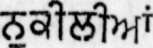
ਨੁਕੀਲੀਆਂ
